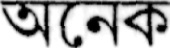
অনেক
